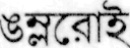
ঙম্লরোই
